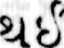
થઈ
